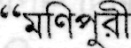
“মণিপুরী
